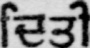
ਦਿਤੀ
